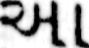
આ
